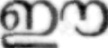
ഈ
